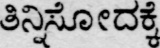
ತಿನ್ನಿಸೋದಕ್ಕೆ
